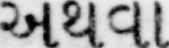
અથવા
